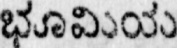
ಭೂಮಿಯ
